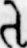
તે
